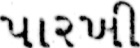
પારખી
